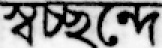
স্বচ্ছন্দে
